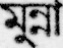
মুন্না
